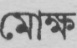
মোক্ষ
